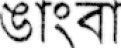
ঙাংবা
